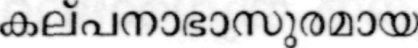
കല്പനാഭാസുരമായ
